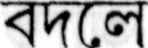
বদলে
